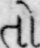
તો
